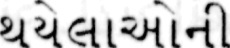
થયેલાઓની
